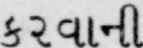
કરવાની
